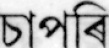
চাপৰি
